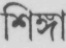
শিঙ্গা
